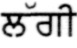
ਲੱਗੀ
